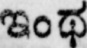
ಇಂಥ
